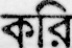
করি
